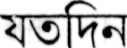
যতদিন
